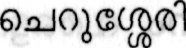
ചെറുശ്ശേരി
